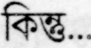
কিন্তু...
